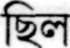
ছিল
